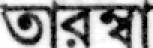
তারম্বা
